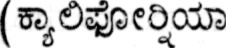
(ಕ್ಯಾಲಿಫೋರ್ನಿಯಾ
